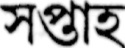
সপ্তাহ
